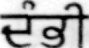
ਦੰਭੀ
